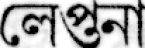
লেপ্তনা
